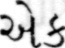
એક
